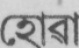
হোৱা
